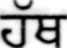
ਹੱਥ
